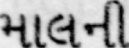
માલની
